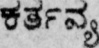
ಕರ್ತವ್ಯ
